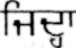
ਜਿਦ੍ਹਾ
